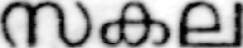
സകല
